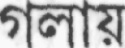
গলায়
